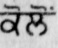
ਕੋਲੋਂ
